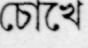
চোখে
